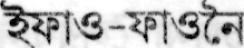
ইফাও-ফাওনৈ
